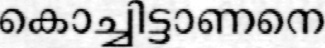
കൊച്ചിട്ടാണനെ
